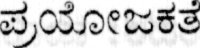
ಪ್ರಯೋಜಕತೆ
